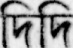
দিদি
